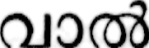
വാല്‍
